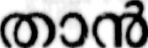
താന്‍
